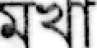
মখা
